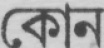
কোন
